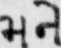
મને
